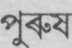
পুৰুষ
